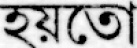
হয়তো
